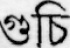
গুচি
